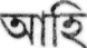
আহি
